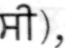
ਸੀ),
